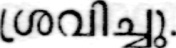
ശ്രവിച്ചു.
